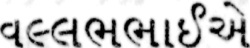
વલ્લભભાઈએ
